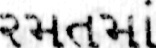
રમતમાં
